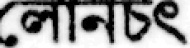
লোনচৎ
